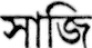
সাজি
